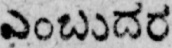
ಎಂಬುದರ
